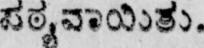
ಪಠ್ಯವಾಯಿತು.
